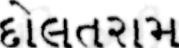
દોલતરામ
